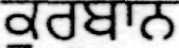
ਕੁਰਬਾਨ
